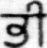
ਭੀ
